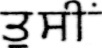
ਤੁਸੀਂ
